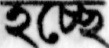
হচ্ছে
